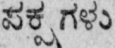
ಪಕ್ಷಗಳು
